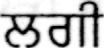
ਲਗੀ
